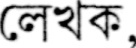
লেখক,
